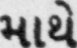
માથે
